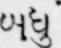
બધું
